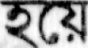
হয়ে
